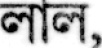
লাল,
